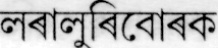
লৰালুৰিবোৰক
